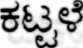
ಕಟ್ಟಳೆ
